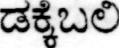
ಡಕ್ಕೆಬಲಿ
